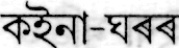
কইনা-ঘৰৰ
